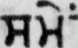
ਸਮੇਂ
